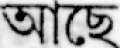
আছে
